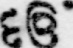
દઉં
